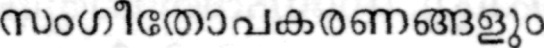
സംഗീതോപകരണങ്ങളും
